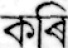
কৰি
